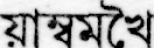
য়াম্বমখৈ
